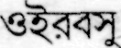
ওইরবসু
